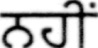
ਨਹੀਂ
